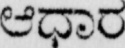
ಆಧಾರ
